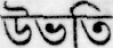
উভতি
